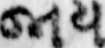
જાય
